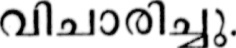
വിചാരിച്ചു.
